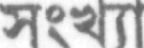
সংখ্যা
